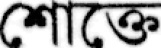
শোক্তে
